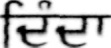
ਦਿੰਦਾ
